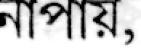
নাপায়,
